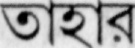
তাহার
